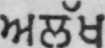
ਅਲੱਖ
